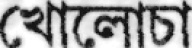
খোলোচা
